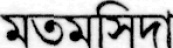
মতমসিদা
